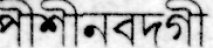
পীশীনবদগী
